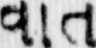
વાત
